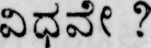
ವಿಧವೇ?
